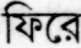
ফিরে
